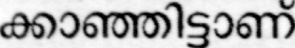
ക്കാഞ്ഞിട്ടാണ്
